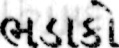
ભડાકો
